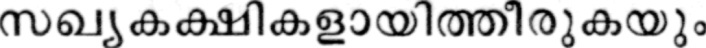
സഖ്യകക്ഷികളായിത്തീരുകയും
